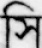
সি
